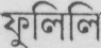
ফুলিলি
